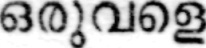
ഒരുവളെ
